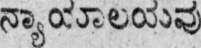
ನ್ಯಾಯಾಲಯವು
